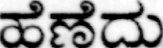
ಹೆಣೆದು
